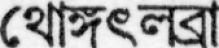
থোঙ্গৎলব্রা
